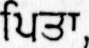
ਪਿਤਾ,
